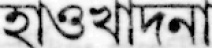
হাওখাদনা
